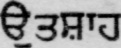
ਉਤਸ਼ਾਹ
